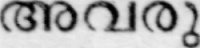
അവരു
